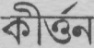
কীৰ্ত্তন
